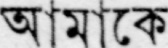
আমাকে
